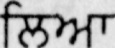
ਲਿਆ
